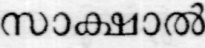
സാക്ഷാല്‍
